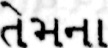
તેમના
